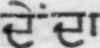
ਦੇਂਦਾ
